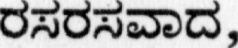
ರಸರಸವಾದ,
